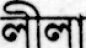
লীলা
